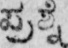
ಪ್ರಶ್ನೆ
